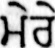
ਮੇਰੇ
